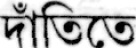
দাঁতিতে
